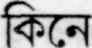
কিনে
